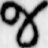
જ
